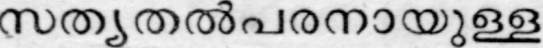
സത്യതല്‍പരനായുള്ള
